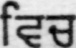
ਵਿਚ
